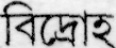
বিদ্ৰোহ
